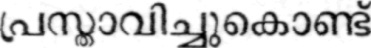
പ്രസ്താവിച്ചുകൊണ്ട്
